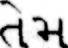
તેમ
